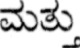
ಮತ್ತು
